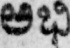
ಅಭಿ
